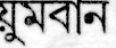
য়ুমবান
